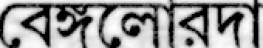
বেঙ্গলোরদা
